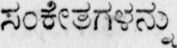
ಸಂಕೇತಗಳನ್ನು
